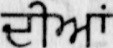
ਦੀਆਂ
